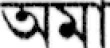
অমা
